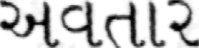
અવતાર
